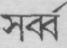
সৰ্ব্ব
